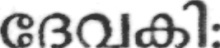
ദേവകി:
